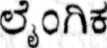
ಲೈಂಗಿಕ
